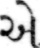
એ
